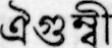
ঐগুম্বী
